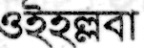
ওইহল্লবা
